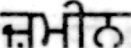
ਜ਼ਮੀਨ
